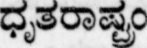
ಧೃತರಾಷ್ಟ್ರಂ
